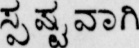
ಸ್ಪಷ್ಟವಾಗಿ
